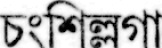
চংশিল্লগা
